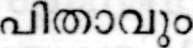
പിതാവും
